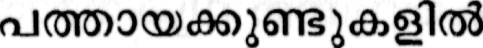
പത്തായക്കുണ്ടുകളില്‍
